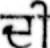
ਦੀ
